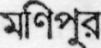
মণিপুর
